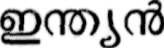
ഇന്ത്യന്‍
